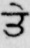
ਤੇ
